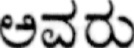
ಅವರು
